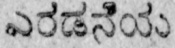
ಎರಡನೆಯ
